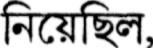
নিয়েছিল,
